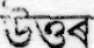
উত্তৰ
